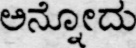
ಅನ್ನೋದು
